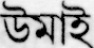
উমাই
